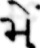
મેં
